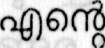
എന്റെ
